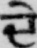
ਦੇ
